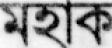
মহাক
